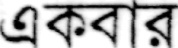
একবার
